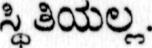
ಸ್ಥಿತಿಯಲ್ಲ.
